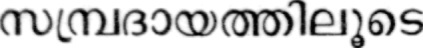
സമ്പ്രദായത്തിലൂടെ
